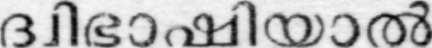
ദ്വിഭാഷിയാല്‍
